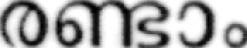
രണ്ടാം
